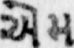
એમ
